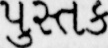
પુસ્તક
